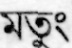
মতুং
